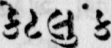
કેટલુંક
